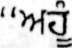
''ਅਹੂੰ
